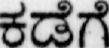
ಕಡೆಗೆ
